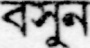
বসুন
